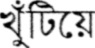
খুঁটিয়ে
